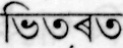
ভিতৰত
